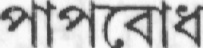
পাপবোধ
